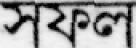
সফল
